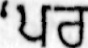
'ਪਰ
